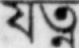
যত্ন
